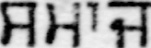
ਸਮਾਜ
